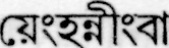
য়েংহন্নীংবা
